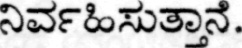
ನಿರ್ವಹಿಸುತ್ತಾನೆ.
